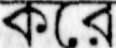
করে
